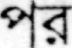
পর
